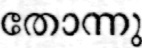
തോന്നു
